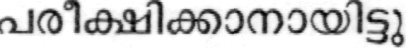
പരീക്ഷിക്കാനായിട്ടു
